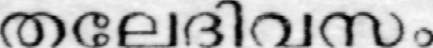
തലേദിവസം
